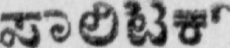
ಪಾಲಿಟಿಕ್
